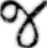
જ
